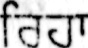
ਰਿਹਾ
